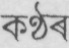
কণ্ঠৰ
